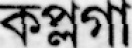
কপ্লগা
